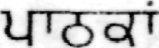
ਪਾਠਕਾਂ
